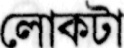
লোকটা
